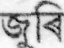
জুৰি
